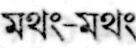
মথং-মথং
